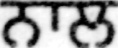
ਨਾਲ
